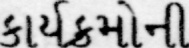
કાર્યક્રમોની
